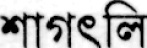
শাগৎলি
